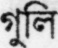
গুলি
